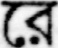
রে
